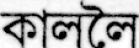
কাললৈ
